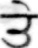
ਤੇ
